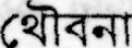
থৌবনা
